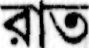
রাত
